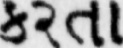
કરતા
